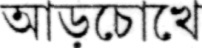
আড়চোখে
